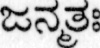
ಜನ್ಮತಃ
